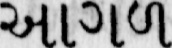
આગળ
